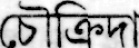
চৌক্রিদা
